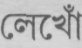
লেখোঁ
